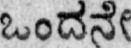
ಒಂದನೇ
